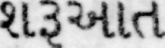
શરૂઆત
